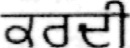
ਕਰਦੀ
